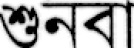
শুনবা
